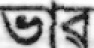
ভাৱ
